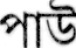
পাউ
